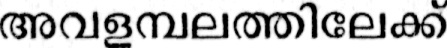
അവളമ്പലത്തിലേക്ക്
